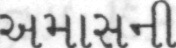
અમાસની
